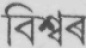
বিশ্বৰ
